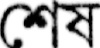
শেষ
